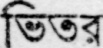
ভিতর
